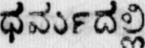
ಧರ್ಮದಲ್ಲಿ
